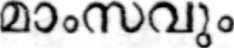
മാംസവും
